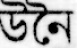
উনৈ
